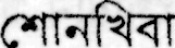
শোনখিবা
